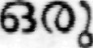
ഒരു
